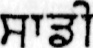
ਸਾਡੀ
